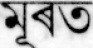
মূৰত
